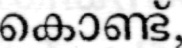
കൊണ്ട്,
